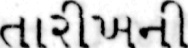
તારીખની
